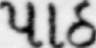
પાઠ
